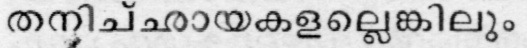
തനിച്ഛായകളല്ലെങ്കിലും
